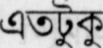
এতটুকু
